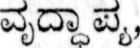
ವೃದ್ಧಾಪ್ಯ,
